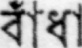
বাঁধা
